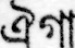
ঐগা
